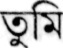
তুমি
